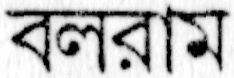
বলরাম
